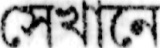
সেখানে
